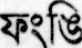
ফংঙি
